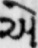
એ
